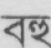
বহু
